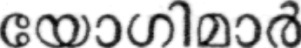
യോഗിമാര്‍
